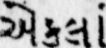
એકલાં
